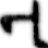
ન
